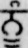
ਨੂੰ
